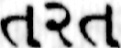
તરત
